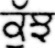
ਕੁੱਝ
